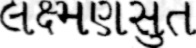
લક્ષ્મણસુત
